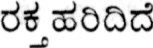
ರಕ್ತಹರಿದಿದೆ
